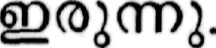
ഇരുന്നു.
